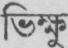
ভিক্ষু
